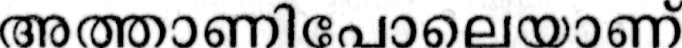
അത്താണിപോലെയാണ്
